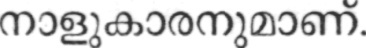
നാളുകാരനുമാണ്.
